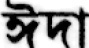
ঈদা
